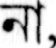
না,
